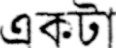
একটা
